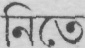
নিতে
